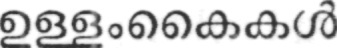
ഉള്ളംകൈകള്‍
